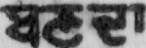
ਬਣਦਾ
